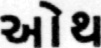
ઓથ
